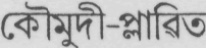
কৌমুদী-প্লাৱিত
